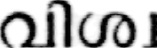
വിശ്വ
